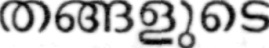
തങ്ങളുടെ
